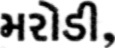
મરોડી,
